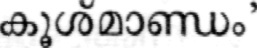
കൂശ്മാണ്ഡം’
